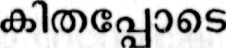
കിതപ്പോടെ
